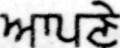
ਆਪਣੇ
